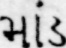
માંડ
